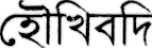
হৌখিবদি
